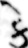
કે
